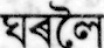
ঘৰলৈ
